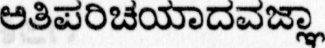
ಅತಿಪರಿಚಯಾದವಜ್ಞಾ
